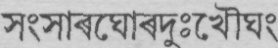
সংসাৰঘোৰদুঃখৌঘং
